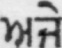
ਅਜੇ
